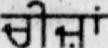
ਚੀਜ਼ਾਂ
